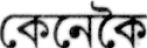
কেনেকৈ
